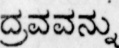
ದ್ರವವನ್ನು
